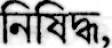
নিষিদ্ধ,
